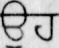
ਉਹ
